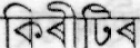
কিৰীটিৰ
